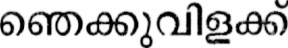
ഞെക്കുവിളക്ക്
